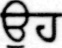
ਉਹ
